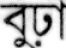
বুঢ়া
